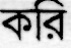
করি
